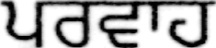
ਪਰਵਾਹ
